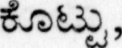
ಕೊಟ್ಟು,
